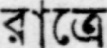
রাত্রে
